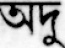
অদু
